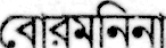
বোরমনিনা
